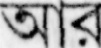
আর
